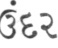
ઉંદર
